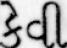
કેવી
